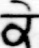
ਕੇ
